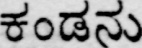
ಕಂಡನು
